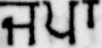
ਜਪਾ
